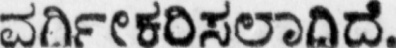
ವರ್ಗೀಕರಿಸಲಾಗಿದೆ.
